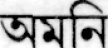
অমনি
